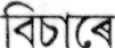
বিচাৰে
